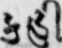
કહી
